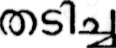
തടിച്ച
